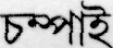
চম্পাই
